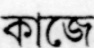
কাজে
